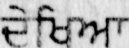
ਦੇਖਿਆ
